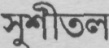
সুশীতল
